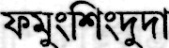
ফমুংশিংদুদা
